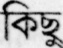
কিছু
